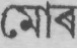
মোৰ
